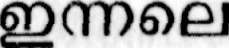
ഇന്നലെ
